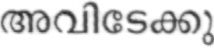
അവിടേക്കു
